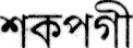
শকপগী
